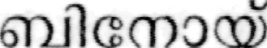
ബിനോയ്
